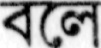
বলে
